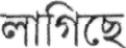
লাগিছে
